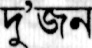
দু'জন
